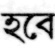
হবে
